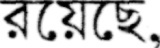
রয়েছে,
